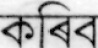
কৰিব
